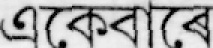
একেবাৰে
